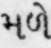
મળે
